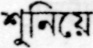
শুনিয়ে
